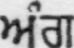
ਅੰਗ
